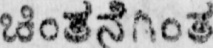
ಚಿಂತನೆಗಿಂತ
